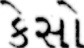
કેસો
